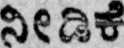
ನೀಡಿಕೆ
